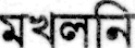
মখলনি
